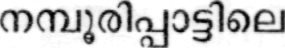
നമ്പൂരിപ്പാട്ടിലെ
